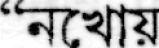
“নখোয়
